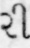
રી
